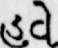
હવે
